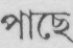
পাছে
